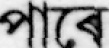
পাৰে
